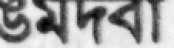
ঙমদবা
